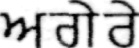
ਅਗੇਰੇ
